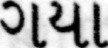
ગયા
